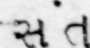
સંત
